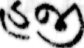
હજી
